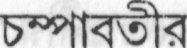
চম্পাবতীর
